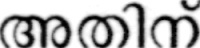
അതിന്
